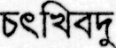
চৎখিবদু
